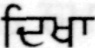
ਦਿਖਾ
